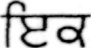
ਇਕ
